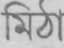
মিঠা
